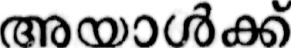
അയാള്‍ക്ക്
